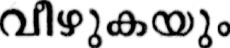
വീഴുകയും
